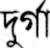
দুর্গা
